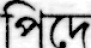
পিদে
